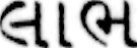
લાભ
